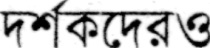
দর্শকদেরও
